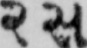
રસ
